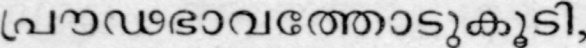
പ്രൌഢഭാവത്തോടുകൂടി,
